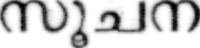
സൂചന
